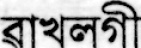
ৱাখলগী
